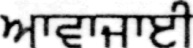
ਆਵਾਜਾਈ
